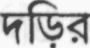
দড়ির
